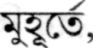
মুহূর্তে,
